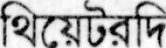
থিয়েটরদি
